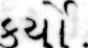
કર્યો.
